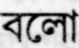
বলো
